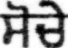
ਸੋਚੇ
